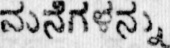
ಮನೆಗಳನ್ನು
